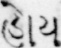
હોય
